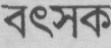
বৎসক
